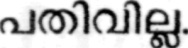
പതിവില്ല.
